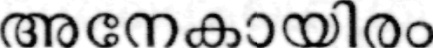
അനേകായിരം
